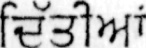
ਦਿੱਤੀਆਂ
